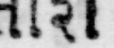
તારા
